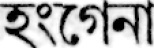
হংগেনা
